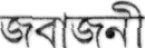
জবাজনী
